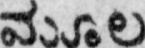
ಮೂಲ
